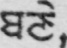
ਬਣੇ,
